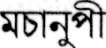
মচানুপী
